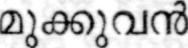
മുക്കുവന്‍
